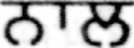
ਨਾਲ
